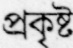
প্রকৃষ্ট
